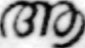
ആ
